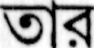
তার
